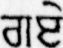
ਗਏ
